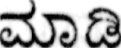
ಮಾಡಿ
